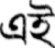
এই
